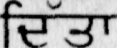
ਦਿੱਤਾ
